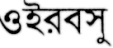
ওইরবসু
